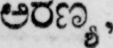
ಅರಣ್ಯ,
